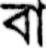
বা
